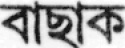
বাছাক
